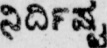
ನಿರ್ದಿಷ್ಟ
